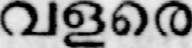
വളരെ
